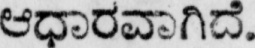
ಆಧಾರವಾಗಿದೆ.
